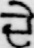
ਦੇ
